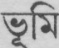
ভূমি
